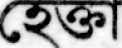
হেক্তা
